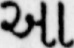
આ
